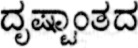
ದೃಷ್ಟಾಂತದ
